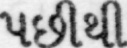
પછીથી
